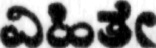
ವಿಹಿತೇ
